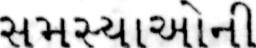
સમસ્યાઓની
